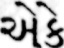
એકે
